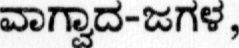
ವಾಗ್ವಾದ-ಜಗಳ,
